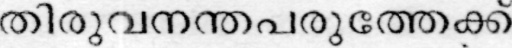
തിരുവനന്തപുരത്തേക്ക്
